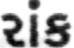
રાંક
